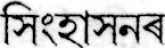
সিংহাসনৰ
